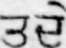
ਤਦੇ
